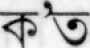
ক'ত
